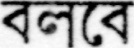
বলবে
